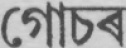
গোচৰ
